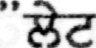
''ਲੇਟ
